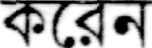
করেন
